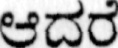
ಆದರೆ
